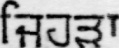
ਜਿਹੜਾ
